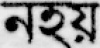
নহয়
